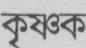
কৃষ্ণক
